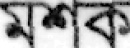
মশক
